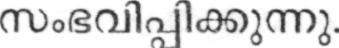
സംഭവിപ്പിക്കുന്നു.
